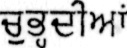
ਚੁਭ੍ਹਦੀਆਂ
